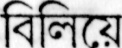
বিলিয়ে
